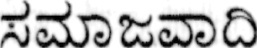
ಸಮಾಜವಾದಿ
